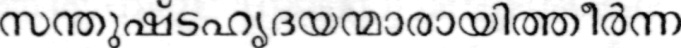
സന്തുഷ്ടഹൃദയന്മാരായിത്തീര്‍ന്ന
